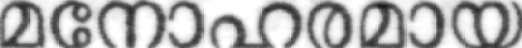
മനോഹരമായ
